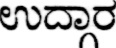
ಉದ್ಗಾರ
